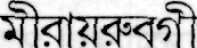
মীরায়রুবগী
